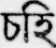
চহি
